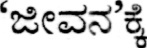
'ಜೀವನ'ಕ್ಕೆ
